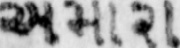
અમારા
